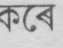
কৰে
